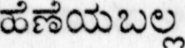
ಹೆಣೆಯಬಲ್ಲ
